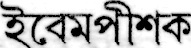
ইবেমপীশক
